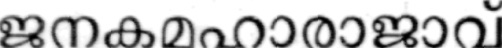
ജനകമഹാരാജാവ്
